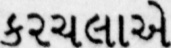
કરચલાએ
